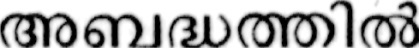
അബദ്ധത്തില്‍
